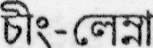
চীং-লেম্লা
